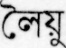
লৈয়ু
